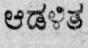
ಆಡಳಿತ
